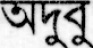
অদুবু
